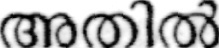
അതില്‍
